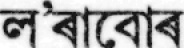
ল'ৰাবোৰ
